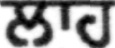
ਲਾਹ
